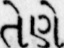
તેણે
